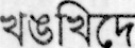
খঙখিদে
